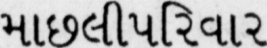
માછલીપરિવાર
